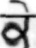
ਕੇ
